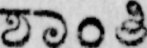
ಶಾಂತಿ
